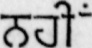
ਨਹੀਂ
